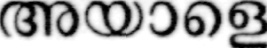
അയാളെ
